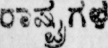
ರಾಷ್ಟ್ರಗಳ
